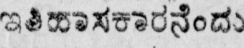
ಇತಿಹಾಸಕಾರನೆಂದು
